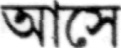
আসে
